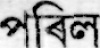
পৰিল
